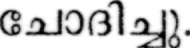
ചോദിച്ചു.
